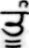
ਤੂੰ
